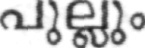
പുല്ലും
